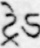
ટ્રેડ
